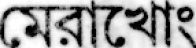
মেরাখোং
